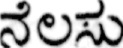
ನೆಲಸು
